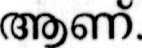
ആണ്.
